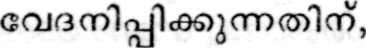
വേദനിപ്പിക്കുന്നതിന്,
